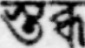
স্তব্ধ
